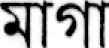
মাগা
